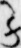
કે
